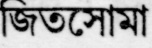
জিতসোমা
